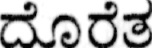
ದೊರೆತ
